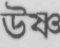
উষ্ণ
